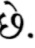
છે.
